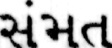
સંમત
